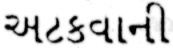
અટકવાની
